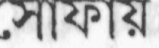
সোফায়
